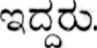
ಇದ್ದರು.
